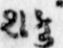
શકું
